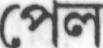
পেল
